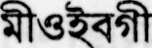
মীওইবগী
